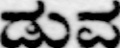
ಡುವ
